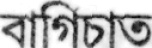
বাগিচাত
